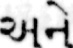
અને
